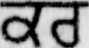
ਕਰ
